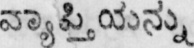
ವ್ಯಾಪ್ತಿಯನ್ನು
